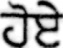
ਹੋਏ
